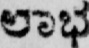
ಲಾಭ
